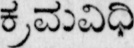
ಕ್ರಮವಿಧಿ
